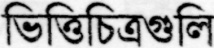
ভিত্তিচিত্রগুলি
